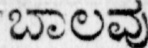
ಬಾಲವು
